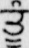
ਤੂੰ
